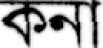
কনা
